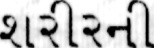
શરીરની
